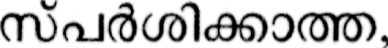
സ്പര്‍ശിക്കാത്ത,
